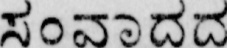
ಸಂವಾದದ
